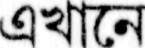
এখানে
